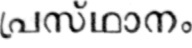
പ്രസ്ഥാനം
